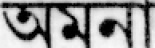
অমনা
